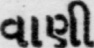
વાણી
